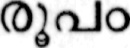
രൂപം
